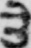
ਤੇ
